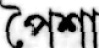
পৈশা
